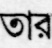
তার
